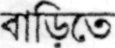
বাড়িতে
